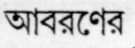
আবরণের
